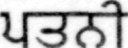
ਪਤਨੀ
